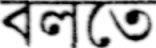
বলতে
